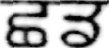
ਛਡ
